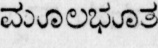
ಮೂಲಭೂತ
